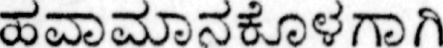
ಹವಾಮಾನಕೊಳಗಾಗಿ
